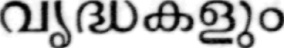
വൃദ്ധകളും
